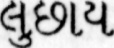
લુછાય
